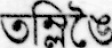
তম্লিঙৈ
